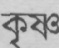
কৃষ্ণ
